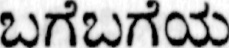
ಬಗೆಬಗೆಯ
